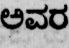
ಅವರ
